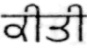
ਕੀਤੀ
